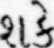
શકે
